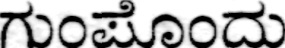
ಗುಂಪೊಂದು
